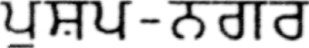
ਪੁਸ਼ਪ-ਨਗਰ
